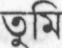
তুমি
